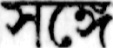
সঙ্গে
